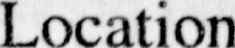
Location
